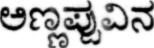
ಅಣ್ಣಪ್ಪುವಿನ
